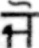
ਜੋ
